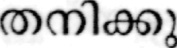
തനിക്കു
